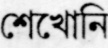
শেখোনি
